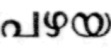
പഴയ
